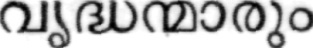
വൃദ്ധന്മാരും
